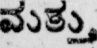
ಮತ್ತು
